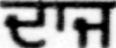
ਦਾਜ
